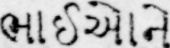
ભાઈઓને
